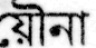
য়ৌনা
